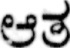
ಆತ
